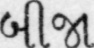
બીજા
